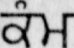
ਕੰਮ
